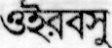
ওইরবসু
